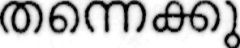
തന്നെക്കു
